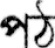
পঠ
